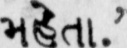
મહેતા.'
